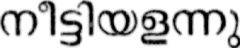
നീട്ടിയളന്നു
